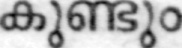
കുണ്ടും
